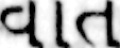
વાત
